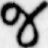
જ
